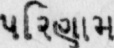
પરિણામ
